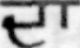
ਦਾ
